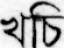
খচি
